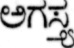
ಅಗಸ್ತ್ಯ
